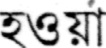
হওয়া
